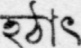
হঠাৎ
